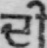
ਦੀ
